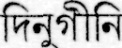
দিনুগীনি
